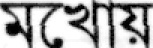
মখোয়
